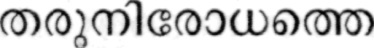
തരുനിരോധത്തെ
